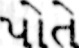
પોતે
